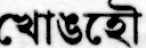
খোঙহৌ
